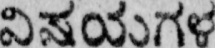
ವಿಷಯಗಳ
